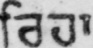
ਰਿਹਾ
